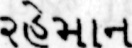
રહેમાન
